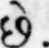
છે.
